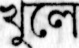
খুলে
